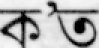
ক'ত
